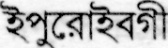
ইপুরোইবগী
